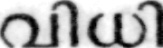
വിധി
